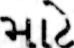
માટે
